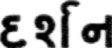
દર્શન
